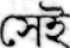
সেই
